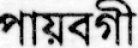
পায়বগী
